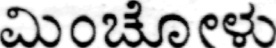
ಮಿಂಚೋಳು
